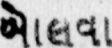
બોલવા
